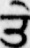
ਤੇ
